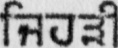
ਜਿਹੜੀ
